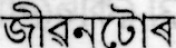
জীৱনটোৰ
